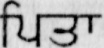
ਪਿਤਾ
